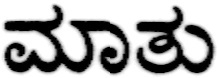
ಮಾತು
